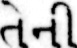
તેની
